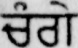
ਚੰਗੇ
